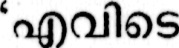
'എവിടെ
